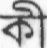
কী
